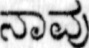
ನಾವು
